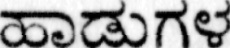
ಹಾಡುಗಳ
